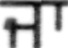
ਜਾ
